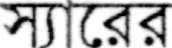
স্যারের
